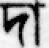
দা
